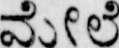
ಮೇಲೆ
